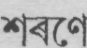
শৰণে
